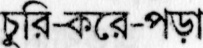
চুরি-করে-পড়া
